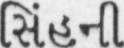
સિંહની
